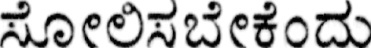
ಸೋಲಿಸಬೇಕೆಂದು
